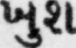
ખુશ
